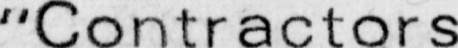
“Contractors
